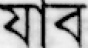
যাব
